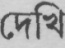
দেখি
